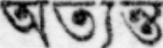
অত্যন্ত
